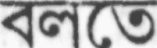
বলতে
